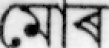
মোৰ
